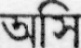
অসি
